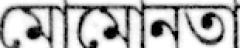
মোমোনতা
